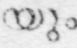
യും
